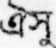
ঐসু
